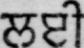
ਲਈ
